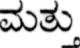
ಮತ್ತು
